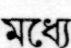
মধ্যে
